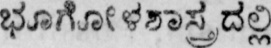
ಭೂಗೋಳಶಾಸ್ತ್ರದಲ್ಲಿ
